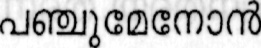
പഞ്ചുമേനോന്‍
